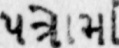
પત્રોમાં
